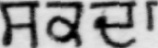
ਸਕਦਾ
